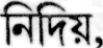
নিদিয়,
